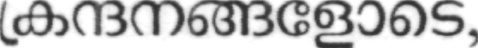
ക്രന്ദനങ്ങളോടെ,
